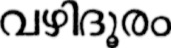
വഴിദൂരം
